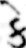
કે
